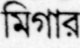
মিগার
